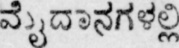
ಮೈದಾನಗಳಲ್ಲಿ
